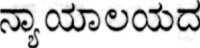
ನ್ಯಾಯಾಲಯದ
